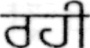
ਰਹੀ
